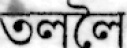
তললৈ
